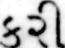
કરી
